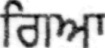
ਗਿਆ
